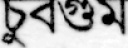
চুবগুম
